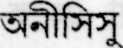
অনীসিসু
